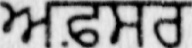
ਅਫ਼ਸਰ
